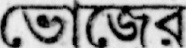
ভোজের
